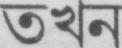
তখন
